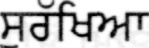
ਸੁਰੱਖਿਆ
